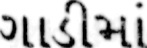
ગાડીમાં
